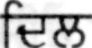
ਦਿਲ
